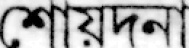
শোয়দনা
